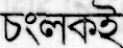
চংলকই
